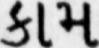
કામ
